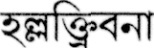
হল্লক্ত্রিবনা
